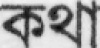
কথা
